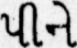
પીને
